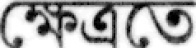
ক্ষেত্রতে
